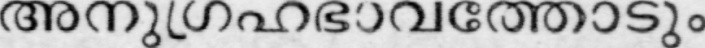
അനുഗ്രഹഭാവത്തോടും
